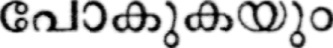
പോകുകയും
